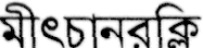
মীৎচানরক্লি
